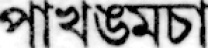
পাখঙমচা
